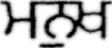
ਮਨੁਖ
